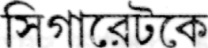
সিগারেটকে
